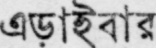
এড়াইবার
